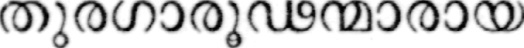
തുരഗാരൂഢന്മാരായ
